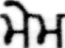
ਮੇਮ
